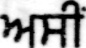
ਅਸੀਂ
